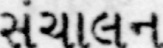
સંચાલન
